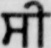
ਸੀ
